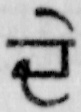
ਦੇ
